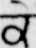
ਕੇ
